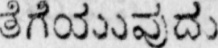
ತೆಗೆಯುವುದು
